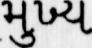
મુખ્ય
